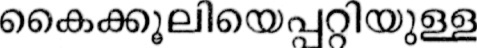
കൈക്കൂലിയെപ്പറ്റിയുള്ള
